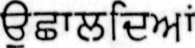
ਉਛਾਲਦਿਆਂ
